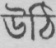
উঠি
